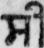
ਸੀ
